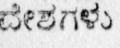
ದೇಶಗಳು
